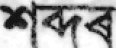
শব্দৰ
